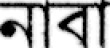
নাবা
